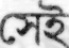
সেই
